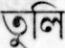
তুলি
